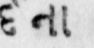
દર્દના
